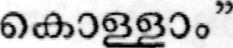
കൊള്ളാം”
